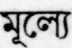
মূল্যে
